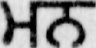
ਮਨ
